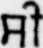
ਸੀ
